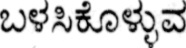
ಬಳಸಿಕೊಳ್ಳುವ
